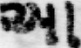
આ
